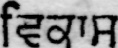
ਵਿਕਾਸ
